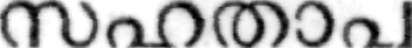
സഹതാപ
